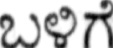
ಬಳಿಗೆ
